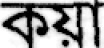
কয়া
